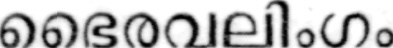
ഭൈരവലിംഗം
